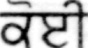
ਕੋਈ
